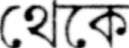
থেকে
